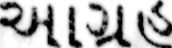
આગ્રહ
